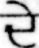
ਦੇ
